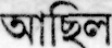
আছিল
